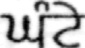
ਘੰਟੇ
